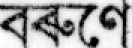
বৰুণে
